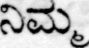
ನಿಮ್ಮ
